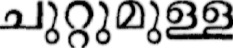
ചുറ്റുമുള്ള
